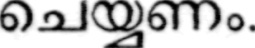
ചെയ്യണം.
